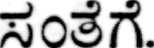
ಸಂತೆಗೆ.
